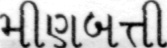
મીણબત્તી
